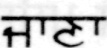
ਜਾਣਾ
